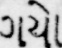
ગયો
